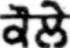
ਕੌਲੇ
